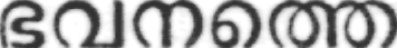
ഭവനത്തെ
